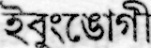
ইবুংঙোগী
